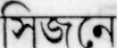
সিজনে
